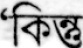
'কিন্তু
